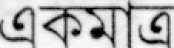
একমাত্র
